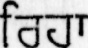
ਰਿਹਾ
